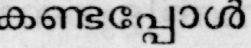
കണ്ടപ്പോള്‍
